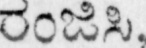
ರಂಜಿಸಿ,
